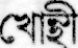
খোন্থী
